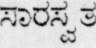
ಸಾರಸ್ವತ
